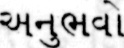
અનુભવો
